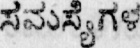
ಸಮಸ್ಯೆಗಳ
